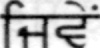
ਜਿਵੇਂ
